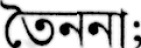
তৈননা;
